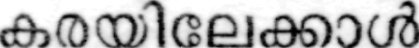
കരയിലേക്കാള്‍
